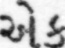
એક
